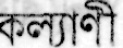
কল্যাণী
